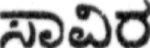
ಸಾವಿರ
